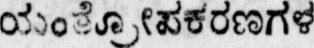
ಯಂತ್ರೋಪಕರಣಗಳ
